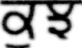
ਕੁਝ
